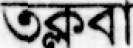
তক্লবা
